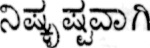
ನಿಷ್ಕೃಷ್ಟವಾಗಿ
